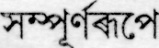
সম্পূর্ণৰূপে
